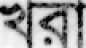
খরা
